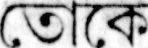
তোকে
